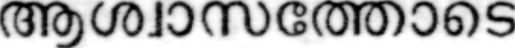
ആശ്വാസത്തോടെ
